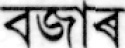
বজাৰ
